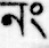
নং
